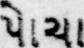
પોચા
